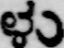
ಳು
